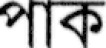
পাক
